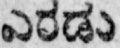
ಎರಡು
